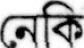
নেকি
